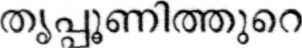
തൃപ്പൂണിത്തുറെ
